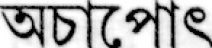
অচোপোৎ
